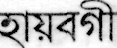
হায়বগী
